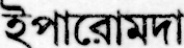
ইপারোমদা
